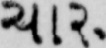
ચાર
